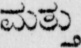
ಮತ್ತು
